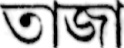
তাজা
